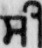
ਸੀ
